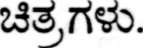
ಚಿತ್ರಗಳು.
